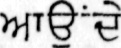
ਆਉਂਦੇ
